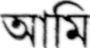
আমি
